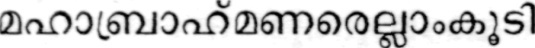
മഹാബ്രാഹ്മണരെല്ലാംകൂടി
